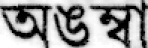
অঙম্বা
